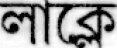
লাক্লে
